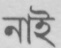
নাই
